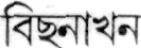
বিছনাখন
